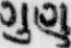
ગુણ
